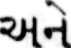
અને
